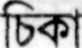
চিকা
